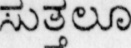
ಸುತ್ತಲೂ
